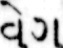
વેગ
